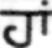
ਹਾਂ
